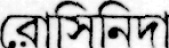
রোসিনিদা
